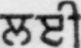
ਲਈ
